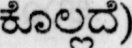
ಕೊಲ್ಲದೆ)
